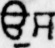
ਉਸ
